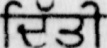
ਦਿੱਤੀ
